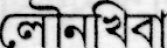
লৌনখিবা
